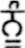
ਨੂੰ
